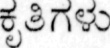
ಕೃತಿಗಳು
